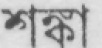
শঙ্কা
